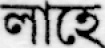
লাহে
